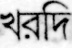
খরদি
